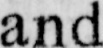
and
